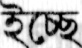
ইচ্ছে
